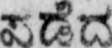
ಪಡೆದ
